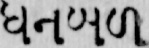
ધનબળ
